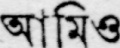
আমিও
